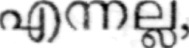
എന്നല്ല,
